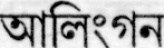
আলিংগন
